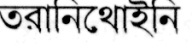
তরানিথোইনি
